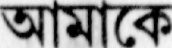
আমাকে
